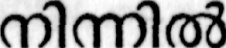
നിന്നില്‍
